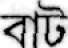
বাট
